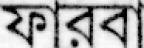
ফারবা
